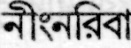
নীংনরিবা
